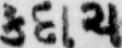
કદાચ
